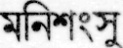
মনিশংসু
